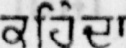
ਕਹਿੰਦਾ
